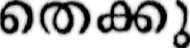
തെക്കു
